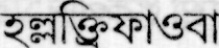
হল্লক্ত্রিফাওবা
